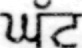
ਘੱਟ
